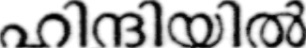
ഹിന്ദിയില്‍
